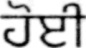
ਹੋਈ
